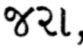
જરા,
